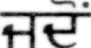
ਜਦੋਂ
